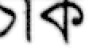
চাক
